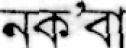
নক'বা
